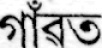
গাঁৱত
